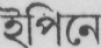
ইপিনে
